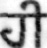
ਹੀ
